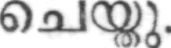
ചെയ്തു.
